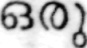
ഒരു
